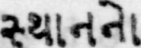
સ્થાનનો
